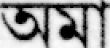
অমা
